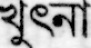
খুৎনা
